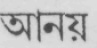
আনয়
